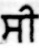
ਸੀ
